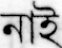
নাই
